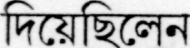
দিয়েছিলেন
